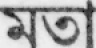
মতা
